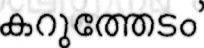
കറുത്തേടം'
